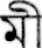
মী
